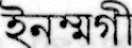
ইনম্মগী
